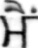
ਮੈਂ
